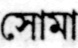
সোমা
